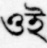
ওই
